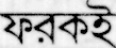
ফরকই
